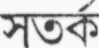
সতর্ক
